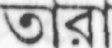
তারা
